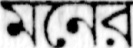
মনের
